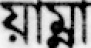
য়াম্না
